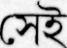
সেই
